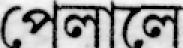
পেলালে
